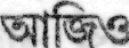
আজিও
